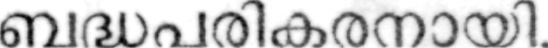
ബദ്ധപരികരനായി.
